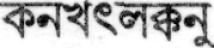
কনখৎলক্কনু
